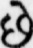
છે
